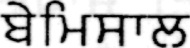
ਬੇਮਿਸਾਲ
